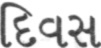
દિવસ
